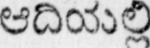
ಆದಿಯಲ್ಲಿ
